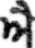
ਐ
